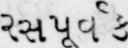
રસપૂર્વક
